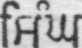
ਸਿੰਘ
